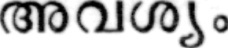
അവശ്യം
